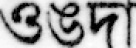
ওঙদা
